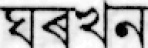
ঘৰখন
